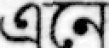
এনে
